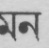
মন
